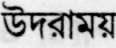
উদরাময়
